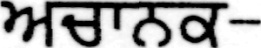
ਅਚਾਨਕ-
